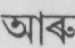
আৰু
